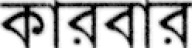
কারবার
